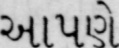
આપણે
